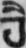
ਹੈ
